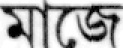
মাজে
